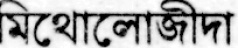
মিথোলোজীদা
